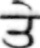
ਤੇ
